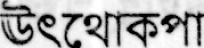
ঊৎথোকপা
